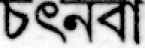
চৎনবা
